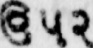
ઉપર
